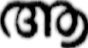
ആ
